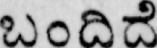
ಬಂದಿದೆ
